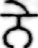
ਨੇ
